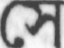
সে
